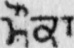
ਮੌਕਾ
